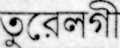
তুরেলগী
